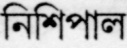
নিশিপাল
